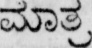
ಮಾತ್ರ
